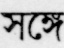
সঙ্গে
